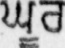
ਘੂਰ
